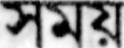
সময়
